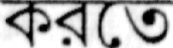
করতে
